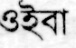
ওইবা
